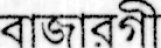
বাজারগী
